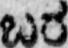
ಬರ
